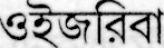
ওইজরিবা
